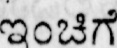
ಇಂಚಿಗೆ
